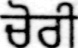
ਚੋਰੀ
